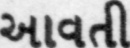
આવતી
